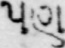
પણ
